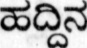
ಹದ್ದಿನ
